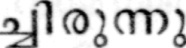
ച്ചിരുന്നു
